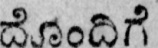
ದೊಂದಿಗೆ
